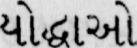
યોદ્ધાઓ
